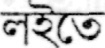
লইতে
